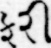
ફરી
